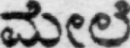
ಮೇಲೆ
